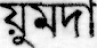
য়ুমদা
